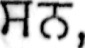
ਸਨ,
